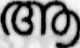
ആ
